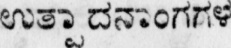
ಉತ್ಪಾದನಾಂಗಗಳ
